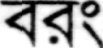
বরং
